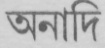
অনাদি
